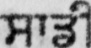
ਸਾਡੀ
